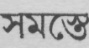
সমস্তে
